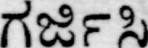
ಗರ್ಜಿಸಿ
